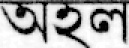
অহল
